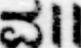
ವ||
